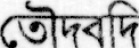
তৌদবদি
